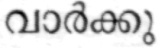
വാര്‍ക്കു
